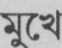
মুখে
